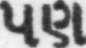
પણ
